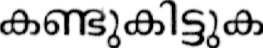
കണ്ടുകിട്ടുക
